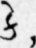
કે,
